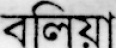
বলিয়া
